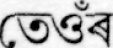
তেওঁৰ
